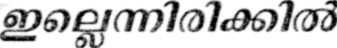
ഇല്ലെന്നിരിക്കില്‍
